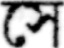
সে
